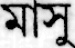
মাসু
